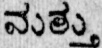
ಮತ್ತು
